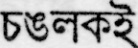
চঙলকই
